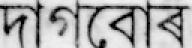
দাগবোৰ
